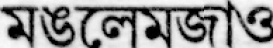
মঙলেমজাও
